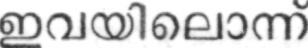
ഇവയിലൊന്ന്
